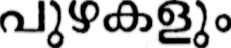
പുഴകളും
